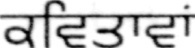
ਕਵਿਤਾਵਾਂ
